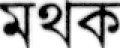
মথক
